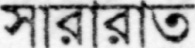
সারারাত
